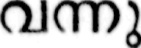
വന്നു
